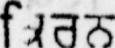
ਕਿਰਨ
